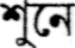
শুনে
